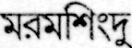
মরমশিংদু
